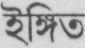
ইঙ্গিত
